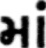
માં
